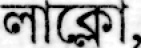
লাক্লো,
